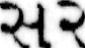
સર
